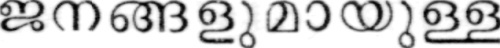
ജനങ്ങളുമായുള്ള
